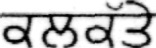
ਕਲਕੱਤੇ
